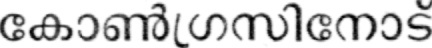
കോണ്‍ഗ്രസിനോട്
